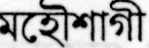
মহৌশাগী
